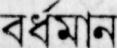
বর্ধমান
